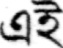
এই
